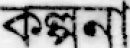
কল্পনা
